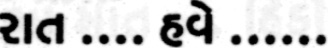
રાત....હવે......
